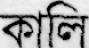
কালি
